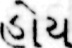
હોય
